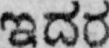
ಇದರ
